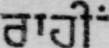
ਰਾਹੀਂ
